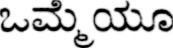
ಒಮ್ಮೆಯೂ
